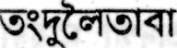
তংদুলৈতাবা
